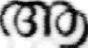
ആ
